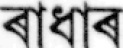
ৰাধাৰ
